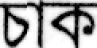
চাক
